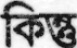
কিন্তু
